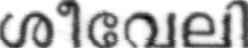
ശീവേലി
